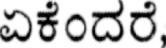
ಏಕೆಂದರೆ,
